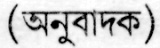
(অনুবাদক)
